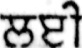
ਲਈ
